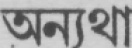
অন্যথা
